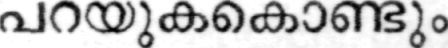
പറയുകകൊണ്ടും
